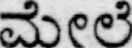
ಮೇಲೆ
